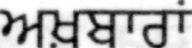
ਅਖ਼ਬਾਰਾਂ
